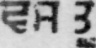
ਵਸਤੂ
